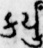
કર્યું
